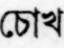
চোখ
